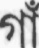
গাঁ
